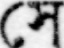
সে
